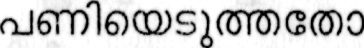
പണിയെടുത്തതോ
